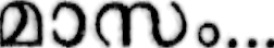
മാസം...
